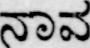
ನಾವ
